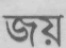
জয়
